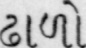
ઢાળો
